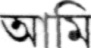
আমি
